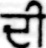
ਦੀ
